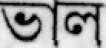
ভাল
